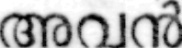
അവന്‍
